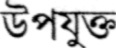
উপযুক্ত
